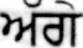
ਅੱਗੇ
